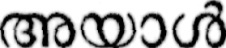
അയാള്‍
